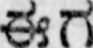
ಈಗ
